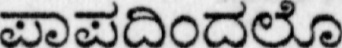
ಪಾಪದಿಂದಲೊ
